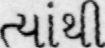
ત્યાંથી
